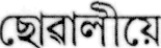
ছোৱালীয়ে
